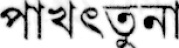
পাখৎতুনা
